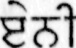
ਏਨੀ
